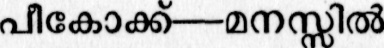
പീകോക്ക്-മനസ്സില്‍
